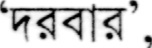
‘দরবার’,
